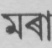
মৰা
